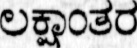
ಲಕ್ಷಾಂತರ
